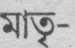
মাতৃ-
